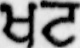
ਖਟ
